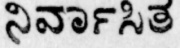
ನಿರ್ವಾಸಿತ
